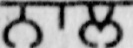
ਨਾਲ
